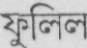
ফুলিল
